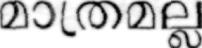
മാത്രമല്ല
